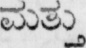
ಮತ್ತು
